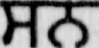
ਸਨ
